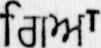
ਗਿਆ
